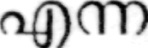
എന്ന
